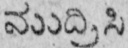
ಮುದ್ರಿಸಿ
